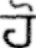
ਹੋ
